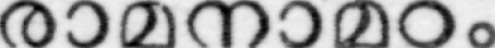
രാമനാമഠം
